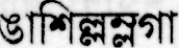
ঙাশিল্লম্লগা
